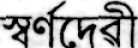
স্বর্ণদেৱী
